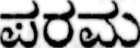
ಪರಮ
